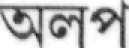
অলপ
